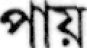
পায়
